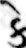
કે
